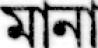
মানা
